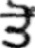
ਤੋਂ
